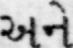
અને
